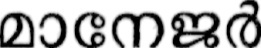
മാനേജര്‍
